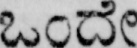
ಒಂದೇ
